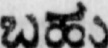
ಬಹು
